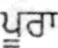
ਪੂਰਾ
